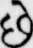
છે
